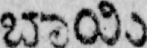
ಬಾಯಿ
